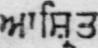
ਆਸ਼੍ਰਿਤ
